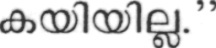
കയിയില്ല."
